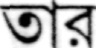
তার
